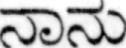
ನಾನು
